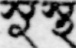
সুস্থ
